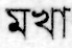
মখা
